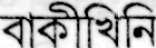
বাকীখিনি
